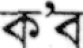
ক'ব
